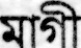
মাগী
